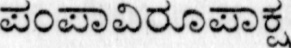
ಪಂಪಾವಿರೂಪಾಕ್ಷ
